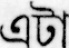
এটা
